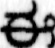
ಈ
